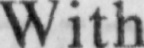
With
